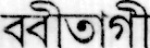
ববীতাগী
